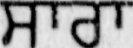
ਸਾਰਾ
